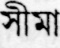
সীমা
